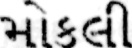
મોકલી
